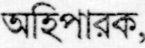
অহিপারক,
